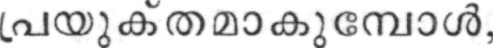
പ്രയുക്തമാകുമ്പോള്‍,
